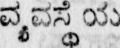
ವ್ಯವಸ್ಥೆಯ
